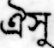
ঐসু
